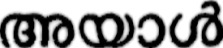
അയാള്‍
